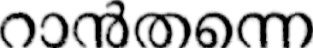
റാന്‍തന്നെ
